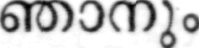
ഞാനും
